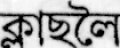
ক্লাছলৈ
